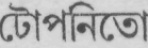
টোপনিতো
